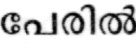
പേരില്‍
